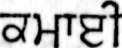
ਕਮਾਈ
